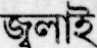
জ্বলাই
